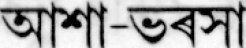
আশা-ভৰসা
